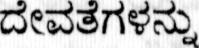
ದೇವತೆಗಳನ್ನು
